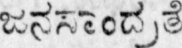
ಜನಸಾಂದ್ರತೆ
